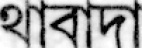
থাবদা
